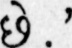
છે.'
